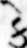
કે
